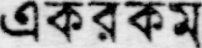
একরকম
